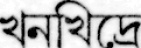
খনখিদ্রে
